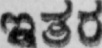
ಇತರ
